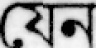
যেন
